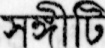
সঙ্গীটি
